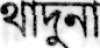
থাদুনা
